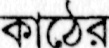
কাঠের
